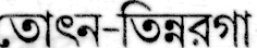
তোৎন-তিন্নরগা
